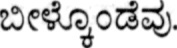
ಬೀಳ್ಕೊಂಡೆವು.
